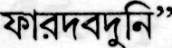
ফারদবদুনি”
